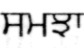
ਸਮਝਾ
